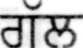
ਗੱਲ
